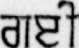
ਗਈ
